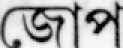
জোপ
